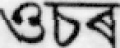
ওচৰ
